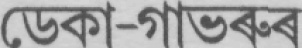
ডেকা-গাভৰুৰ
